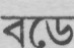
বড়ে
